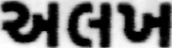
અલખ
